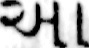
આ
